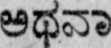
ಅಥವಾ
